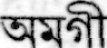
অমগী
